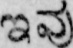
ಇವು
